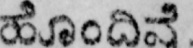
ಹೊಂದಿವೆ.
